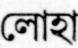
লোহা
